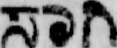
ಸಾಗಿ
